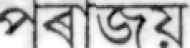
পৰাজয়
